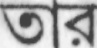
তার
